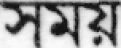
সময়
